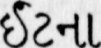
ઈંટના
